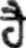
ਹੈ
